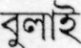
বুলাই
